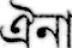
ঐনা
